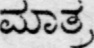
ಮಾತ್ರ
